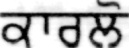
ਕਾਰਲੋ
